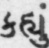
કહ્યું
